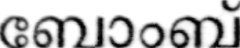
ബോംബ്
